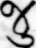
જુ
